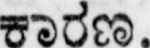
ಕಾರಣ.
